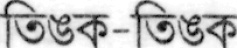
তিঙক-তিঙক
